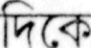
দিকে
